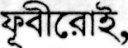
ফূবীরোই,
